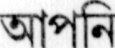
আপনি
